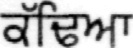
ਕੱਢਿਆ
